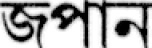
জপান
